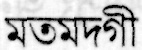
মতমদগী
